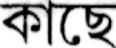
কাছে
